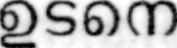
ഉടനെ
